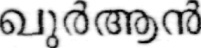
ഖുര്‍ആന്‍
